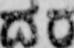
ದರ
